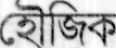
হৌজিক
